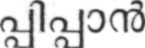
പ്പിപ്പാന്‍
